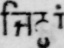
ਜਿਨ੍ਹਾਂ
